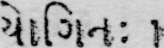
યોગિનઃ
